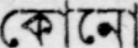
কোনো
